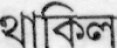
থাকিল
